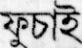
ফুচাই
